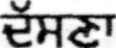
ਦੱਸਣਾ
